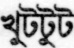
খুটটুট
